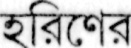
হরিণের
